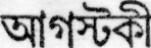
আগস্টকী
